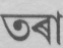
তৰা
